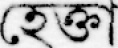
হেক্তা
